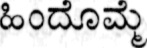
ಹಿಂದೊಮ್ಮೆ
